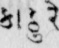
કાઠુરે
